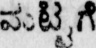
ಮಟ್ಟಿಗೆ
